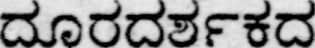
ದೂರದರ್ಶಕದ
